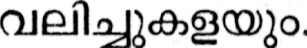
വലിച്ചുകളയും.
